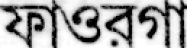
ফাওরগা
